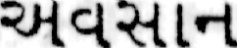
અવસાન
